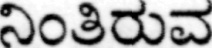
ನಿಂತಿರುವ
